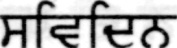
ਸਵਿਦਿਨ
